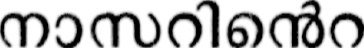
നാസറിന്റെ
